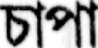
চাপা
